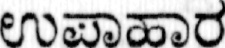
ಉಪಾಹಾರ
